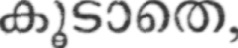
കൂടാതെ,
